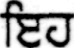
ਇਹ
